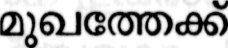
മുഖത്തേക്ക്
